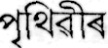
পৃথিৱীৰ
